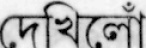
দেখিলোঁ
